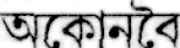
অকোনবৈ
